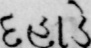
દહાડે
